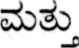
ಮತ್ತು
